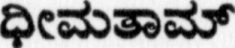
ಧೀಮತಾಮ್
